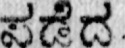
ಪಡೆದ
